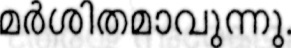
മര്‍ശിതമാവുന്നു.
